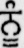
ਨੂੰ
